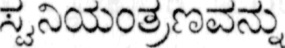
ಸ್ವನಿಯಂತ್ರಣವನ್ನು
